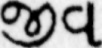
જીવ
